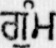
ਗੁੰਮ
